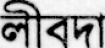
লীবদা
